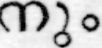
നും
